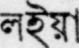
লইয়া
